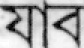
যাব
